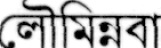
লৌমিন্নবা
